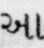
આ
